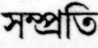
সম্প্রতি
